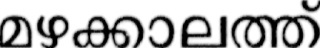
മഴക്കാലത്ത്
